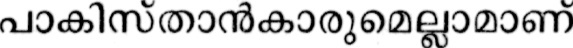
പാകിസ്താന്‍കാരുമെല്ലാമാണ്
